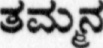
ತಮ್ಮನ
